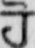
ਹੋ
